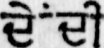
ਦੇਂਦੀ
